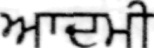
ਆਦਮੀ
